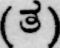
(ತ)
